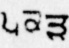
ਪਕੜ
